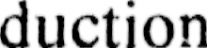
duction
